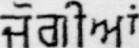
ਜੋਗੀਆਂ
